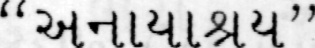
"અનાયાશ્રય"
